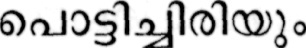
പൊട്ടിച്ചിരിയും
